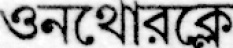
ওনথোরক্লে
